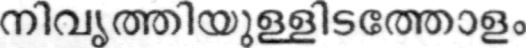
നിവൃത്തിയുള്ളിടത്തോളം
